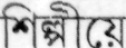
শিল্পীয়ে
